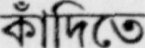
কাঁদিতে
